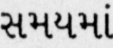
સમયમાં
